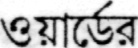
ওয়ার্ডের
